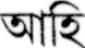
আহি
